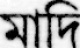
মাদি
